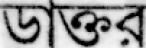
ডাক্তর
